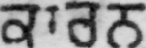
ਕਾਰਨ
